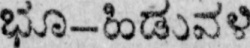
ಭೂ-ಹಿಡುವಳಿ
